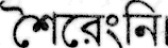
শৈরেংনি।
